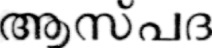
ആസ്പദ
